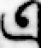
এ
